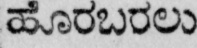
ಹೊರಬರಲು
